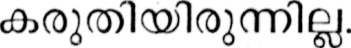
കരുതിയിരുന്നില്ല.
